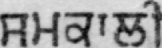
ਸਮਕਾਲੀ
